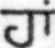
ਹਾਂ
